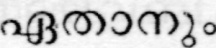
ഏതാനും
